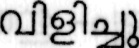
വിളിച്ചു
